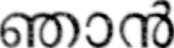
ഞാന്‍
